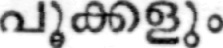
പൂക്കളും
